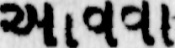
આવવા
